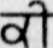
ਕੀ
